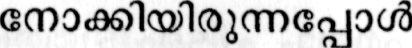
നോക്കിയിരുന്നപ്പോള്‍
